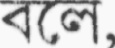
বলে,
